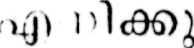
എനിക്കു
